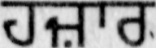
ਹਜ਼ਾਰ
